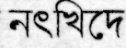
নৎখিদে
